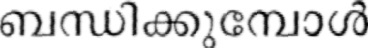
ബന്ധിക്കുമ്പോള്‍
